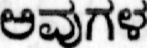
ಅವುಗಳ
